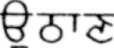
ਉਠਾਣ
